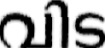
വിട
